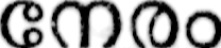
നേരം
